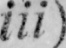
iii)
